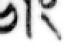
ডাং
